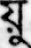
য়ু
